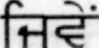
ਜਿਵੇਂ
